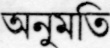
অনুমতি
